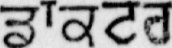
ਡਾਕਟਰ
